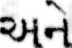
અને
